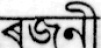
ৰজনী
